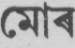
মোৰ
